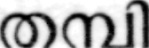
തമ്പി
